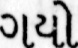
ગયો
